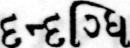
દન્દગ્ધિ
